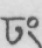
ঢং
